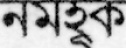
নমহূক
